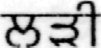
ਲੜੀ
